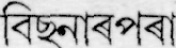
বিছনাৰপৰা
